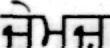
ਜੇਮਜ਼
